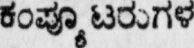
ಕಂಪ್ಯೂಟರುಗಳ
